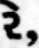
રે,
